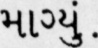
માગ્યું.
